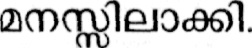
മനസ്സിലാക്കി.
